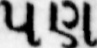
પણ
